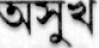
অসুখ
